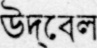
উদ্‌বেল
